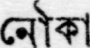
নৌকা
